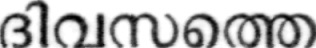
ദിവസത്തെ
